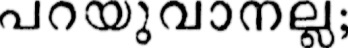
പറയുവാനല്ല;
